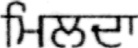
ਮਿਲਦਾ
